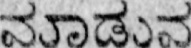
ಮಾಡುವ
